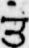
ਤੇ
